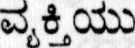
ವ್ಯಕ್ತಿಯು
